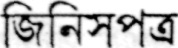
জিনিসপত্র
